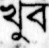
খুব
